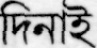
দিনাই
